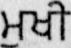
ਮੁਖੀ
